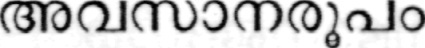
അവസാനരൂപം
